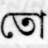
তো
